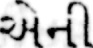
એની
